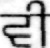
ਵੀ
